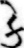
કે
